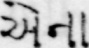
એના
